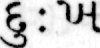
દુઃખ
